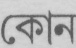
কোন
